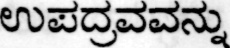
ಉಪದ್ರವವನ್ನು
